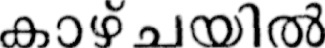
കാഴ്ചയില്‍
